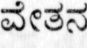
ವೇತನ
